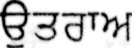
ਉਤਰਾਅ
